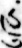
હું
